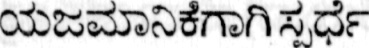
ಯಜಮಾನಿಕೆಗಾಗಿಸ್ಪರ್ಧೆ
